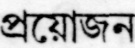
প্রয়োজন
